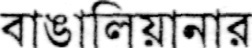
বাঙালিয়ানার
